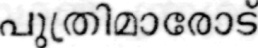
പുത്രിമാരോട്
